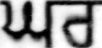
ਘਰ
